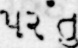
પરંતુ
